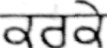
ਕਰਕੇ
